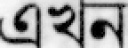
এখন
